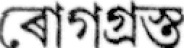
ৰোগগ্রস্ত
